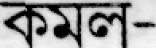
কমল-
